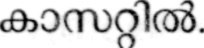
കാസറ്റില്‍.
